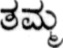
ತಮ್ಮ
